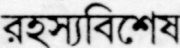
রহস্যবিশেষ
